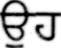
ਉਹ
